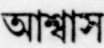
আশ্বাস
